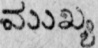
ಮುಖ್ಯ
